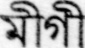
মীগী
